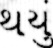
થયું
